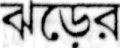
ঝড়ের
